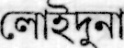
লোইদুনা
